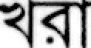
খরা
